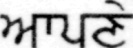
ਆਪਣੇ
